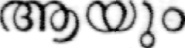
ആയും
